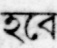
হবে
